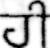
ਹੀ
